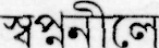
স্বপ্ননীলে
